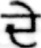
ਦੇ
